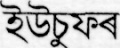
ইউচুফৰ
